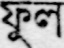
ফুল
